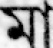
মা
